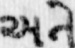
અને
